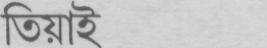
তিয়াই
